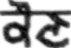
ਕੌਣ
